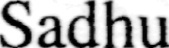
Sadhu
